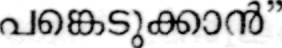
പങ്കെടുക്കാന്‍”
